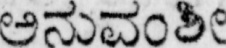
ಅನುವಂಶೀ
